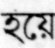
হয়ে
